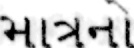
માત્રનો
